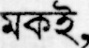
মকই,
